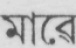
মাৱে
